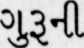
ગુરૂની
